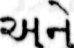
અને
